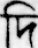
দি
